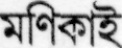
মণিকাই
